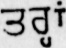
ਤਰ੍ਹਾਂ
